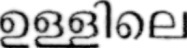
ഉള്ളിലെ
